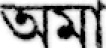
অমা
